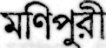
মণিপুরগী
